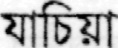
যাচিয়া
